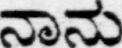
ನಾನು
